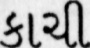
કાચી
